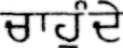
ਚਾਹੁੰਦੇ
